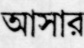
আসার
